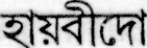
হায়বীদো
